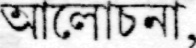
আলোচনা,
